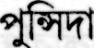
পুন্সিদা
